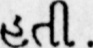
હતી.
